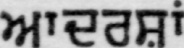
ਆਦਰਸ਼ਾਂ
